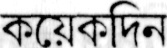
কয়েকদিন
